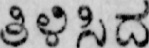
ತಿಳಿಸಿದ
